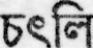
চৎলি
